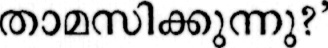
താമസിക്കുന്നു?'
